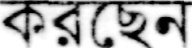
করছেন
